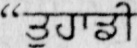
''ਤੁਹਾਡੀ
